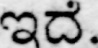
ಇದೆ.
